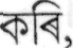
কৰি,
